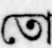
তো
